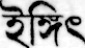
ইঙ্গিৎ
